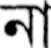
না
